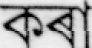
কৰা
